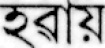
হৱায়
